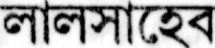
লালসাহেব
